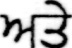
ਅਤੇ
